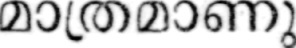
മാത്രമാണു
